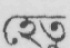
হেতু
